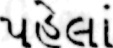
પહેલાં
